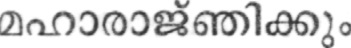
മഹാരാജ്ഞിക്കും
